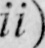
ii)
